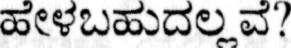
ಹೇಳಬಹುದಲ್ಲವೆ?
